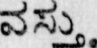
ವಸ್ತು
